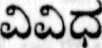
ವಿವಿಧ
